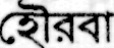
হৌরবা
